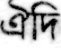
ঐদি
